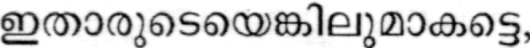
ഇതാരുടെയെങ്കിലുമാകട്ടെ,
